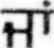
ਜਾਂ
